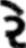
રે
